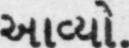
આવ્યો.
